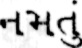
નમતું
